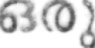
ഒരു
